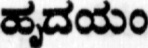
ಹೃದಯಂ
